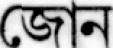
জোন
